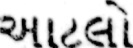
આટલો
